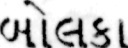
બોલકા
